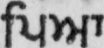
ਪਿਆ
